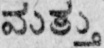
ಮತ್ತು
